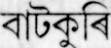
বাটকুৰি
